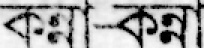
কন্না-কন্না
